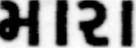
મારા
